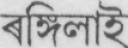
ৰঙ্গিলাই
